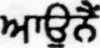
ਆਉਨੈਂ
